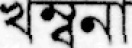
খম্বনা
